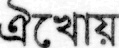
ঐখোয়
